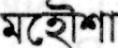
মহৌশা
